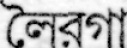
লৈরগা
